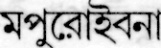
মপুরোইবনা
